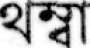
থম্বা
